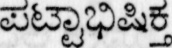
ಪಟ್ಟಾಭಿಷಿಕ್ತ
